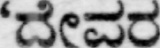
‘ದೇವರ
